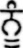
ਨੂੰ
